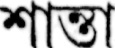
শান্তা
